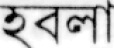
হবলা
